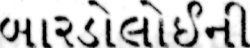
બારોડોલોઈની
